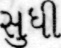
સુધી
